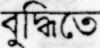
বুদ্ধিতে
